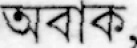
অবাক,
